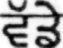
ਵੱਡੇ
